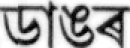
ডাঙৰ
